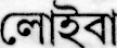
লোইবা
